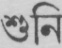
শুনি
